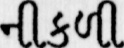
નીકળી
